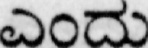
ಎಂದು
